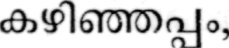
കഴിഞ്ഞപ്പം,
